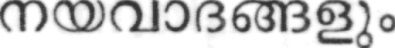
നയവാദങ്ങളും
